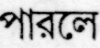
পারলে
